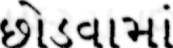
છોડવામાં
